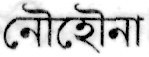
নৌহৌনা
